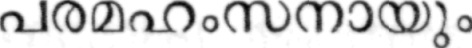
പരമഹംസനായും
